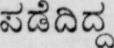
ಪಡೆದಿದ್ದ
